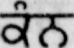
ਕੰਨ
